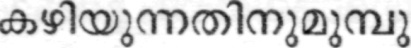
കഴിയുന്നതിനുമുമ്പു
